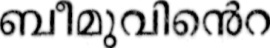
ബീമുവിന്റെ
